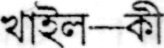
খাইল—কী
